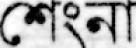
শেংনা
